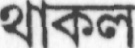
থাকল
